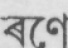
ৰণে
